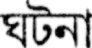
ঘটনা
